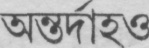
অন্তর্দাহও
